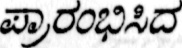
ಪ್ರಾರಂಭಿಸಿದ
